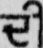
ਦੀ
